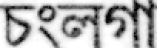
চংলগা
